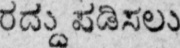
ರದ್ದುಪಡಿಸಲು
